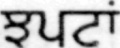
ਝਪਟਾਂ
